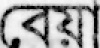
বেয়া
